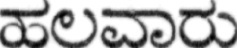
ಹಲವಾರು
